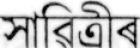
সাৱিত্রীৰ
